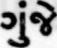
ગુંજે
